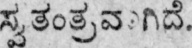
ಸ್ವತಂತ್ರವಾಗಿದೆ.
